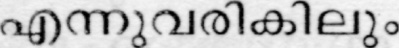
എന്നുവരികിലും
